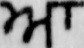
ਆ
